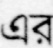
এর
